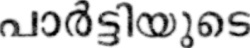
പാര്‍ട്ടിയുടെ
